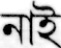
নাই
